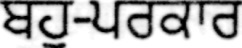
ਬਹੁ-ਪਰਕਾਰ
